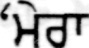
'ਮੇਰਾ
